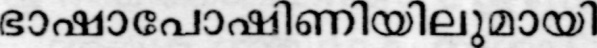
ഭാഷാപോഷിണിയിലുമായി
